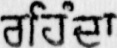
ਰਹਿੰਦਾ
